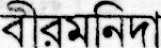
বীরমনিদা
